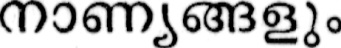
നാണ്യങ്ങളും
